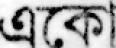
একো
